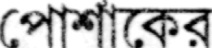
পোশাকের
